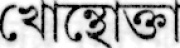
খোন্থোক্তা
